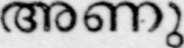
അണു
